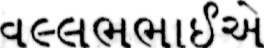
વલ્લભભાઈએ
